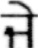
ਜੇ
